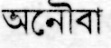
অনৌবা
